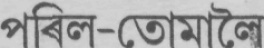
পৰিল-তোমালৈ
